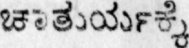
ಚಾತುರ್ಯಕ್ಕೆ
